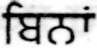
ਬਿਨਾਂ
